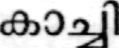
കാച്ചി
